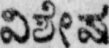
ವಿಶೇಷ
